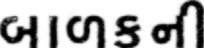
બાળકની
